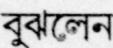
বুঝলেন
